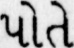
પોતે
